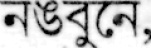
নঙবুনে,
